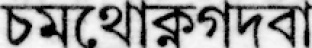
চমথোক্নগদবা
